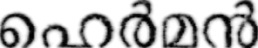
ഹെര്‍മന്‍
